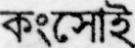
কংসোই
